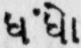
ધંધો
